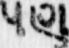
પણ
